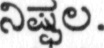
ನಿಷ್ಫಲ.
